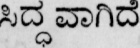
ಸಿದ್ಧವಾಗಿದೆ
